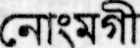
নোংমগী
